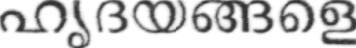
ഹൃദയങ്ങളെ
